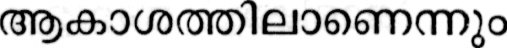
ആകാശത്തിലാണെന്നും
